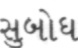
સુબાંધ
